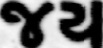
જય
